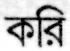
করি
